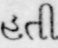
હતી
